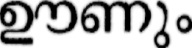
ഊണും
